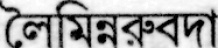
লৈমিন্নরুবদা
